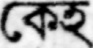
কেহ
